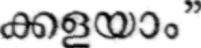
ക്കളയാം”
